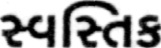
સ્વસ્તિક
